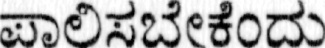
ಪಾಲಿಸಬೇಕೆಂದು
